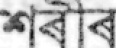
শৰীৰ
